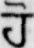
ਹੋ
